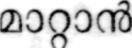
മാറ്റാന്‍
